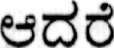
ಆದರೆ
